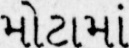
મોટામાં
